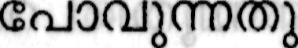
പോവുന്നതു
